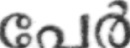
പേര്‍
